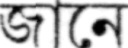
জানে
